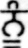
ਨੂੰ
